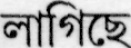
লাগিছে
